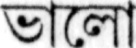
ভালো
